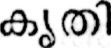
കൃതി
